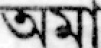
অমা
